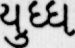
યુધ્ધ
